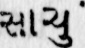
સાચું
